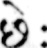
છેઃ
